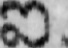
ಐ.
